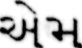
એમ
